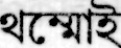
থম্মোই
